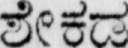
ಶೇಕಡ
